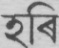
হৰি
